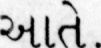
આતે.
